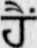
ਹੈਂ
